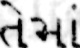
તેમાં
